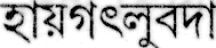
হায়গৎলুবদা
